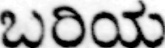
ಬರಿಯ
